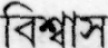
বিশ্বাস
